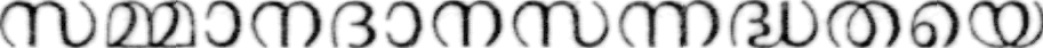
സമ്മാനദാനസന്നദ്ധതയെ
